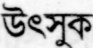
উত্সুক
